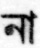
না
